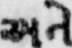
અને
